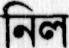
নিল
